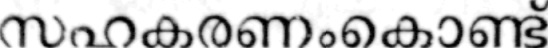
സഹകരണംകൊണ്ട്
